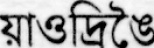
য়াওদ্রিঙৈ
